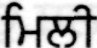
ਮਿਲੀ
